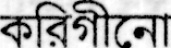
করিগীনো
